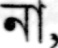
না,
